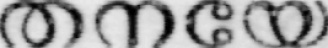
തനയേ
